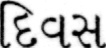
દિવસ
